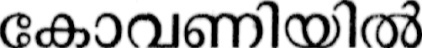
കോവണിയില്‍
